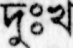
দুঃখ
